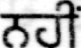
ਨਹੀਂ
